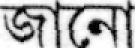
জানো
